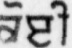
ਕੋਈ
